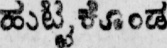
ಹುಟ್ಟಿಕೊಂಡ
